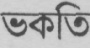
ভকতি
